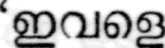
‘ഇവളെ
